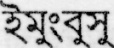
ইমুংবুসূ
